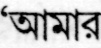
‘আমার
